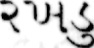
રખડુ
